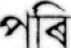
পৰি
